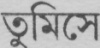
তুমিসে
